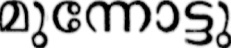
മുന്നോട്ടു
